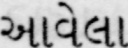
આવેલા
